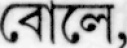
বোলে,
